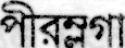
পীরম্লগা
